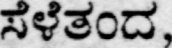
ಸೆಳೆತಂದ,
